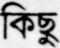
কিছু
